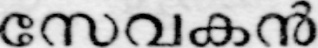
സേവകന്‍
